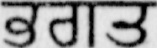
ਭਗਤ
